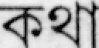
কথা
